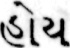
હોય
